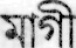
মাগী
